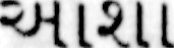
આશા
